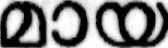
മായ
